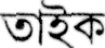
তাইক
